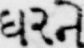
ઘરને
